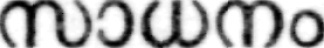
സാധനം
